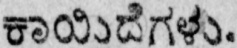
ಕಾಯಿದೆಗಳು.
